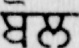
ਬੋਲ
